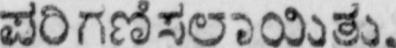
ಪರಿಗಣಿಸಲಾಯಿತು.
